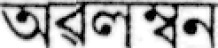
অৱলম্বন
